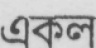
একল
